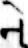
ને
